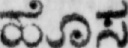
ಹೊಸ
